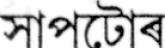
সাপটোৰ
